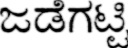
ಜಡೆಗಟ್ಟಿ
